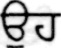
ਉਹ
